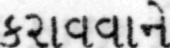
કરાવવાને
